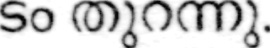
ടംതുറന്നു.
